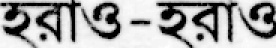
হরাও-হরাও
